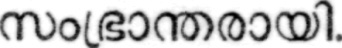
സംഭ്രാന്തരായി.
